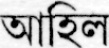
আহিল
